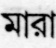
মারা
